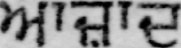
ਆਜ਼ਾਦ
